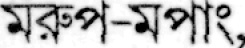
মরুপ-মপাং,
